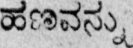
ಹಣವನ್ನು
